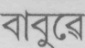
বাবুৱে
